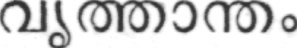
വൃത്താന്തം
